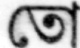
তো
